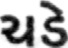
ચડે
